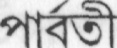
পার্বতী
